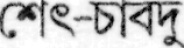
শেৎ-চাবদু
